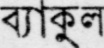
ব্যাকুল
